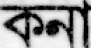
কনা
